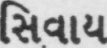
સિવાય
